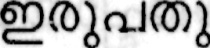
ഇരുപതു
